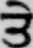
ਤੇ
